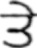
ਤੇ
